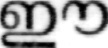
ഈ
